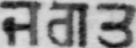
ਜਗਤ
